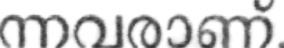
ന്നവരാണ്.
